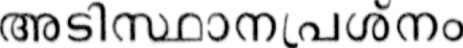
അടിസ്ഥാനപ്രശ്നം
